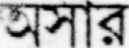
অসার
